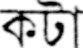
কটা
